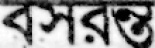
বসরন্ত
